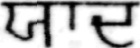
ਯਾਦ
